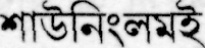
শাউনিংলমই
